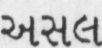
અસલ
